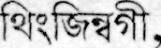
থিংজিন্বগী,
